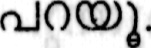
പറയൂ.
